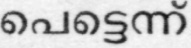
പെട്ടെന്ന്
